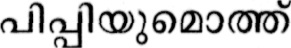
പിപ്പിയുമൊത്ത്
